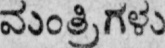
ಮಂತ್ರಿಗಳು
